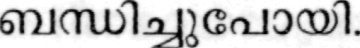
ബന്ധിച്ചുപോയി.
